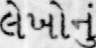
લેખોનું
